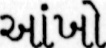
આંખો
